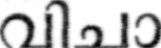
വിചാ
